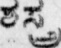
ಶಸ್ತ್ರ
